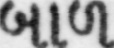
બાળ
